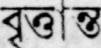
বৃত্তান্ত
